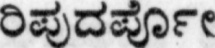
ರಿಪುದರ್ಪೋ
